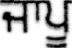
ਜਾਪੂ
